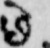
છે.
